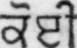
ਕੋਈ
